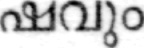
ഷവും
